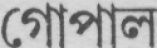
গোপাল
